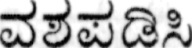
ವಶಪಡಿಸಿ
